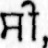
ਸੀ,
